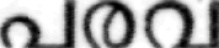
പരവ
